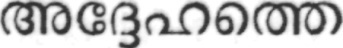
അദ്ദേഹത്തെ
